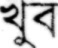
খুব
